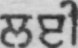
ਲਈ
